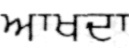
ਆਖਦਾ
